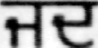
ਜਦ
